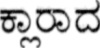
ಕ್ಲಾರಾದ
